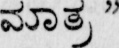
ಮಾತ್ರ”
